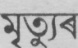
মৃত্যুৰ
